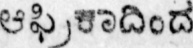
ಆಫ್ರಿಕಾದಿಂದ
